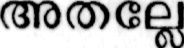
അതല്ലേ
